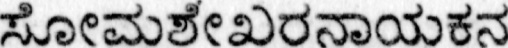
ಸೋಮಶೇಖರನಾಯಕನ
